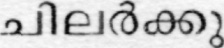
ചിലര്‍ക്കു
